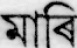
মাৰি
